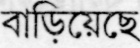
বাড়িয়েছে
